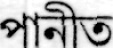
পানীত
